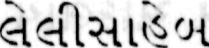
લેલીસાહેબ
